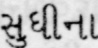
સુધીના
